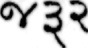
જરૂર
